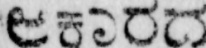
ಅಕಾರದ
